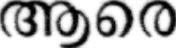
ആരെ
